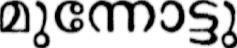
മുന്നോട്ടു
